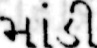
માંડી
